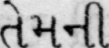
તેમની
